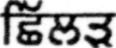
ਛਿੱਲੜ
